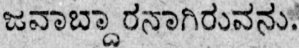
ಜವಾಬ್ದಾರನಾಗಿರುವನು.
